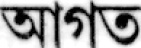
আগত
